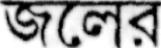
জলের
